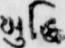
બુદ્ધિ
